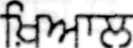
ਖ਼ਿਆਲ
